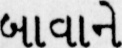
બાવાને
